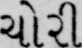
ચોરી
